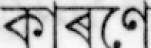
কাৰণে
